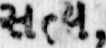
સત્ય,
